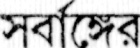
সর্বাঙ্গের
